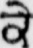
ਕੇ
